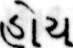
હોય
